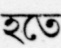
হতে
